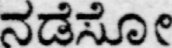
ನಡೆಸೋ
